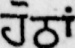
ਹੋਠਾਂ
